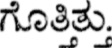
ಗೊತ್ತಿತ್ತು.
